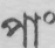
পা
